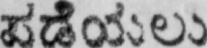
ಪಡೆಯಲು
